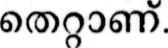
തെറ്റാണ്.
